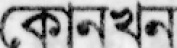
কোনখন
